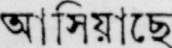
আসিয়াছে
